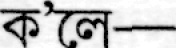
ক'লে-
